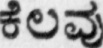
ಕೆಲವು
